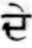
ਦੇ
